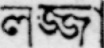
লজ্জা
